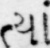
ત્યાં
